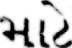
માટે
